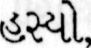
હસ્યો,
